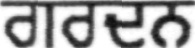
ਗਰਦਨ
